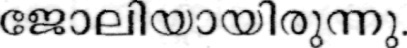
ജോലിയായിരുന്നു.
